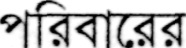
পরিবারের
